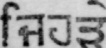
ਜਿਹੜੇ
